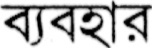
ব্যবহার
